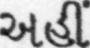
અહીં
